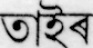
তাইৰ
